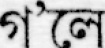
গ'লে
